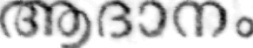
ആദാനം
